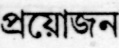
প্রয়োজন
